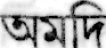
অমদি
